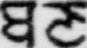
ਬਣ
